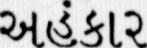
અહંકાર
